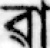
ৱা
